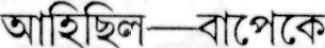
আহিছিল-বাপেকে
